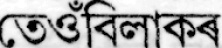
তেওঁবিলাকৰ
